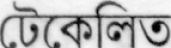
টেকেলিত
